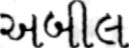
અબીલ
